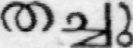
തച്ചു
